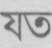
যত
